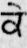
ਕੇ
